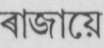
ৰাজায়ে
